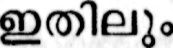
ഇതിലും
